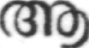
ആ
